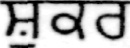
ਸ਼ੁਕਰ
